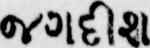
જગદીશ
